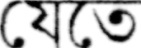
যেতে
